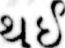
થઈ
